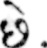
છે.
